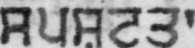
ਸਪਸ਼ਟਤਾ
